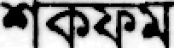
শকফম
